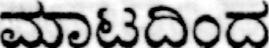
ಮಾಟದಿಂದ
